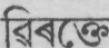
ৱিৰক্তে
